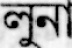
লুনা
